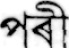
পৰী
